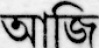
আজি
